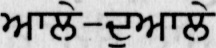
ਆਲੇ-ਦੁਆਲੇ
